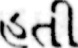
હતી
